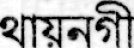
থায়নগী
